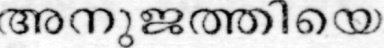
അനുജത്തിയെ
